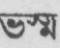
ভস্ম
